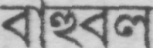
বাহুবল
